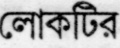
লোকটির
